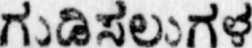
ಗುಡಿಸಲುಗಳ
